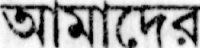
আমাদের
